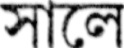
সালে
